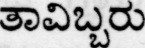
ತಾವಿಬ್ಬರು
